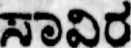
ಸಾವಿರ
